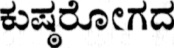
ಕುಷ್ಠರೋಗದ
